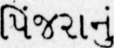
પિંજરાનું
